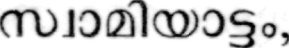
സ്വാമിയാട്ടം,
